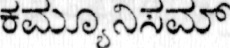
ಕಮ್ಯೂನಿಸಮ್
